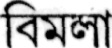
বিমলা
